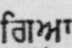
ਗਿਆ
